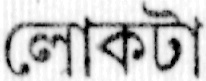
লোকটা
